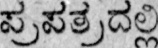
ಪ್ರಪತ್ರದಲ್ಲಿ
